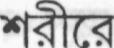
শরীরে
